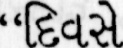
"દિવસે
